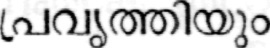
പ്രവൃത്തിയും
